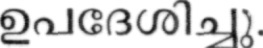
ഉപദേശിച്ചു.
